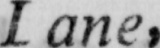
Lane,
